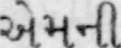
એમની
